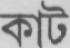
কাট
